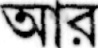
আর
